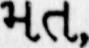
મત,
